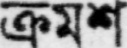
ক্রমশ
